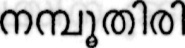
നമ്പൂതിരി
